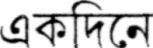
একদিনে
